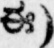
ಈ)
